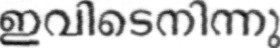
ഇവിടെനിന്നു
